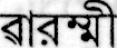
ৱারম্মী
